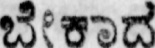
ಬೇಕಾದ
